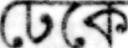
ঢেকে
